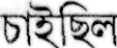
চাইছিল
